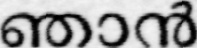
ഞാന്‍
